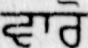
ਵਾਰੋ
